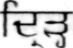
ਦ੍ਰਿੜ੍ਹ
